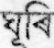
ঘূৰি
